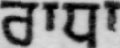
ਰਾਧਾ
